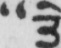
''ਤੇ
